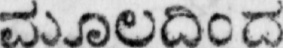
ಮೂಲದಿಂದ
